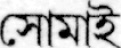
সোমাই
